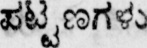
ಪಟ್ಟಣಗಳು
